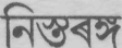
নিস্তৰঙ্গ
